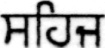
ਸਹਿਜ
